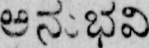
ಅನುಭವಿ
